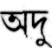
অদু
